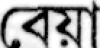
বেয়া
